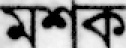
মশক
